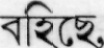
বহিছে,
